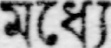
মধ্যে
